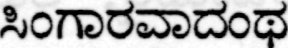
ಸಿಂಗಾರವಾದಂಥ
